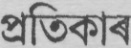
প্ৰতিকাৰ
